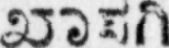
ಖಾಸಗಿ
